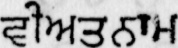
ਵੀਅਤਨਾਮ
